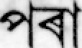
পৰা
